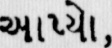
આપ્યો,
